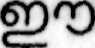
ഈ
